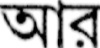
আর
